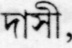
দাসী,
